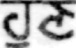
ਹੁਣ
